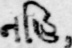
નહિ,
